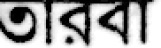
তারবা
